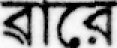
ৱারে
